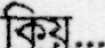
কিয়...
